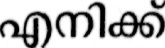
എനിക്ക്
